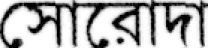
সোরোদা
